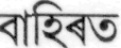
বাহিৰত
